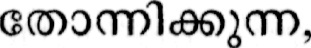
തോന്നിക്കുന്ന,
